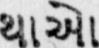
થાઓ
